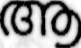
ആ
